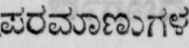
ಪರಮಾಣುಗಳ
